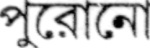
পুরোনো
